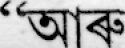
"আৰু
